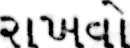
રાખવો
